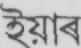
ইয়াৰ
